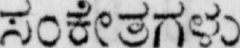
ಸಂಕೇತಗಳು
